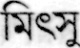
মিৎসু
